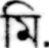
মি.
